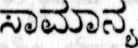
ಸಾಮಾನ್ಯ
